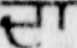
ਦਾ
